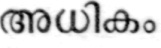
അധികം
